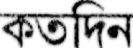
কতদিন
